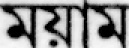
ময়াম
